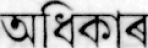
অধিকাৰ
